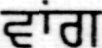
ਵਾਂਗ
